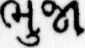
ભુજા
